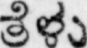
ತೆಳು
